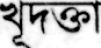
খূদক্তা
